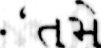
તમે
